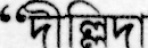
“দীল্লিদা
